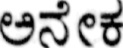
ಅನೇಕ
